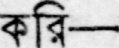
করি—
